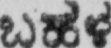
ಬಹಳ
